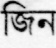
জিন
